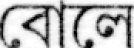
বোলে
